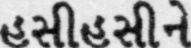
હસીહસીને
